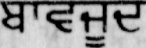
ਬਾਵਜੂਦ
